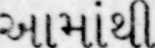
આમાંથી
